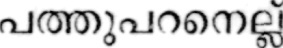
പത്തുപറനെല്ല്
